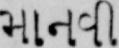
માનવી
